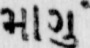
માગું
